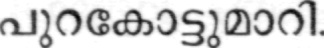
പുറകോട്ടുമാറി.
